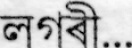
লগৰী...
